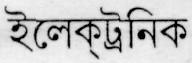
ইলেক্‌ট্রনিক
